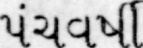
પંચવર્ષી
